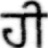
ਹੀ
